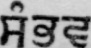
ਸੰਭਵ
